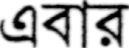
এবার
